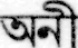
অনী
